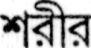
শরীর
